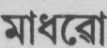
মাধৱো
